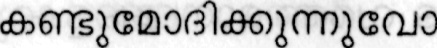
കണ്ടുമോദിക്കുന്നുവോ
